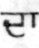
ਦਾ
